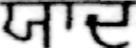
ਯਾਦ
